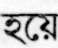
হয়ে
